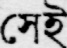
সেই
